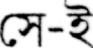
সে-ই
